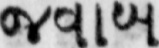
જવાબ
